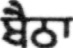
ਬੈਠਾ
